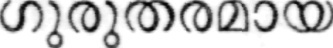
ഗുരുതരമായ
